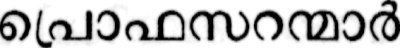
പ്രൊഫസറന്മാര്‍
